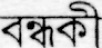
বন্ধকী
